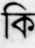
কি
